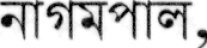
নাগমপাল,
